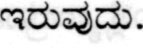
ಇರುವುದು.
